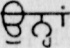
ਉਨ੍ਹਾਂ
